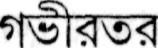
গভীরতর
